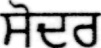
ਸੋਦਰ
